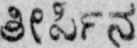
ತೀರ್ಪಿನ
